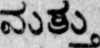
ಮತ್ತು
